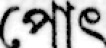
পোৎ
